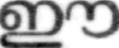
ഈ
